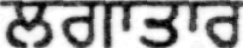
ਲਗਾਤਾਰ
